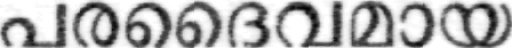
പരദൈവമായ
